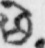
છે.
